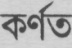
কৰ্ণত
